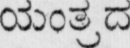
ಯಂತ್ರದ
